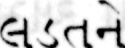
લડતને
